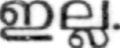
ഇല്ല.
